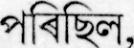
পৰিছিল,
